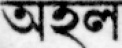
অহল
